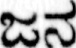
ಜನ
